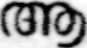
ആ
